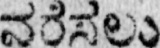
ವರೆಸಲು
